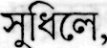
সুধিলে,
